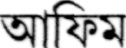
আফিম
